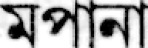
মপানা
